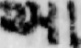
આ
